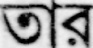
তার
